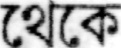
থেকে
